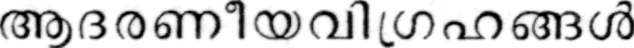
ആദരണീയവിഗ്രഹങ്ങള്‍
